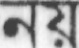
নয়
